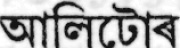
আলিটোৰ
